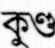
কুণ্ড
